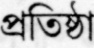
প্রতিষ্ঠা
